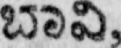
ಬಾವಿ,
